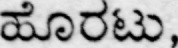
ಹೊರಟು,
